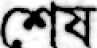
শেষ
